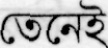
তেনেই
